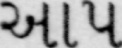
આપ
